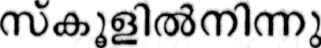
സ്കൂളില്‍നിന്നു
